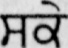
ਸਕੇ
